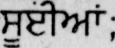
ਸੂਈਆਂ;
